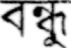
বন্ধু
